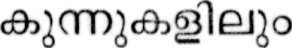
കുന്നുകളിലും
